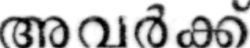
അവര്‍ക്ക്
